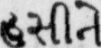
હસીને
